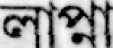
লাপ্না
